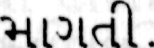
માગતી.
